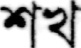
শখ
